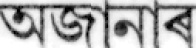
অজানাৰ
